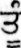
ਤੂੰ
